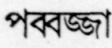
পব্বজ্জা
